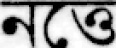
নত্তে
